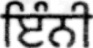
ਇੰਨੀ
